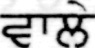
ਵਾਲੇ
